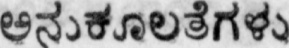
ಅನುಕೂಲತೆಗಳು
